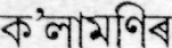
ক'লামণিৰ
